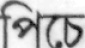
পিচে
